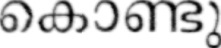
കൊണ്ടു
